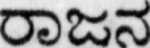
ರಾಜನ
